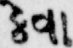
કેવા
